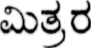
ಮಿತ್ರರ
